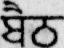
ਬੈਠ
